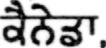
ਕੈਨੇਡਾ,
